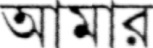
আমার
